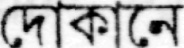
দোকানে
